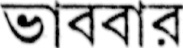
ভাববার
